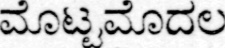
ಮೊಟ್ಟಮೊದಲ
